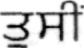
ਤੁਸੀਂ
